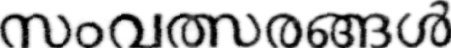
സംവത്സരങ്ങള്‍
